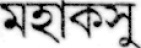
মহাকসু
